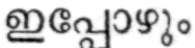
ഇപ്പോഴും
